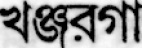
খঞ্জরগা
